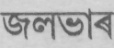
জলভাৰ
